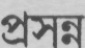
প্ৰসন্ন
